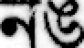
নঙ
